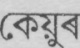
কেয়ুৰ
